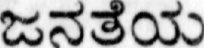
ಜನತೆಯ
